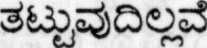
ತಟ್ಟುವುದಿಲ್ಲವೆ
